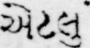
એટલું
